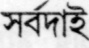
সর্বদাই
